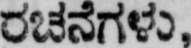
ರಚನೆಗಳು,
